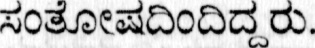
ಸಂತೋಷದಿಂದಿದ್ದರು.
